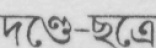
দণ্ডে-ছত্ৰে
